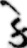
કે
